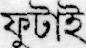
ফুটাই
